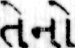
તેનો
